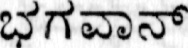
ಭಗವಾನ್
